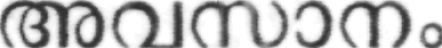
അവസാനം
